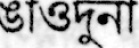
ঙাওদুনা
